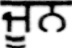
ਜੂਨ
